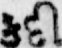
કદી
